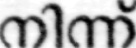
നിന്ന്
